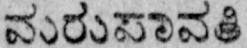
ಮರುಪಾವತಿ
